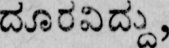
ದೂರವಿದ್ದು,
